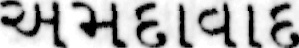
અમદાવાદ
